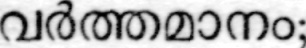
വര്‍ത്തമാനം;
